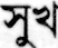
সুখ
